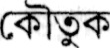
কৌতুক
